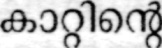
കാറ്റിന്റെ
